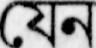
যেন
